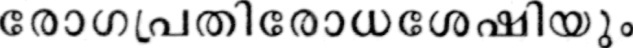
രോഗപ്രതിരോധശേഷിയും
